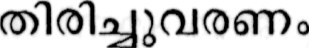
തിരിച്ചുവരണം
